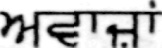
ਅਵਾਜ਼ਾਂ
